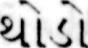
થોડો
